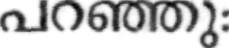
പറഞ്ഞു:
